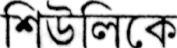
শিউলিকে
